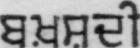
ਬਖ਼ਸ਼ਦੀ
